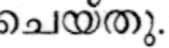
ചെയ്തു.
